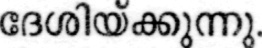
ദേശിയ്ക്കുന്നു.
